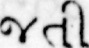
જતી
